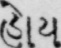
હોય
